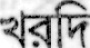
খরদি
